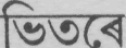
ভিতৰে
